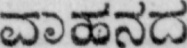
ವಾಹನದ
